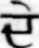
ਦੇ
